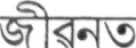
জীৱনত
